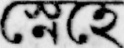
স্নেহে
